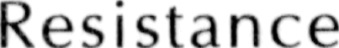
Resistance
